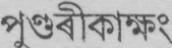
পুণ্ডৰীকাক্ষং
